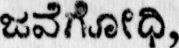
ಜವೆಗೋಧಿ,
